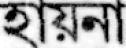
হায়না
